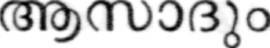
ആസാദും
